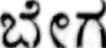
ಬೇಗ
